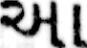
આ
